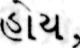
હોય,
